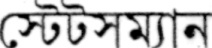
স্টেটসম্যান
